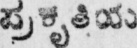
ಪ್ರಕೃತಿಯ
